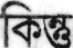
কিন্তু
